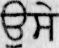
ਉਸੇ
